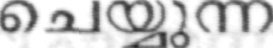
ചെയ്യുന്ന
